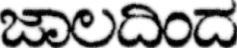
ಜಾಲದಿಂದ
